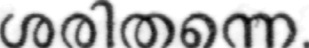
ശരിതന്നെ.
